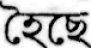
হৈছে
